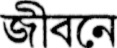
জীবনে
